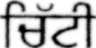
ਚਿੱਟੀ
